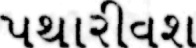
પથારીવશ
